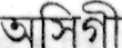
অসিগী
